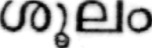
ശൂലം
